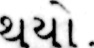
થયો.
